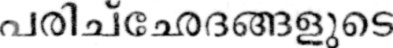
പരിച്ഛേദങ്ങളുടെ
